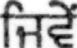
ਜਿਵੇਂ
